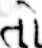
તો
